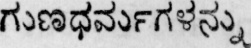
ಗುಣಧರ್ಮಗಳನ್ನು
